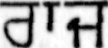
ਰਾਜ
